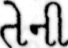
તેની
